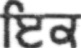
ਇਕ
